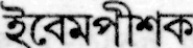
ইবেমপীশক
